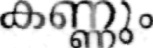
കണ്ണും
